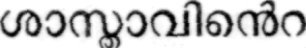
ശാസ്താവിന്റെ
